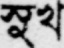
সুখ
